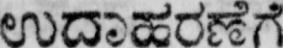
ಉದಾಹರಣೆಗೆ
